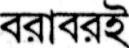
বরাবরই
